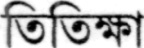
তিতিক্ষা
